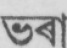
ভৰা
